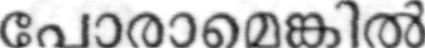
പോരാമെങ്കില്‍
